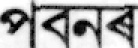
পবনৰ
